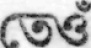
তেওঁ
